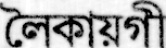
লৈকায়গী
